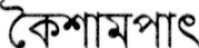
কৈশামপাৎ
